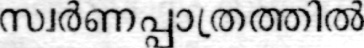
സ്വര്‍ണപ്പാത്രത്തില്‍
